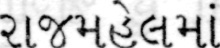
રાજમહેલમાં
